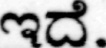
ಇದೆ.
